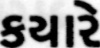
ક્યારે
